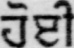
ਹੋਈ
